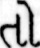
તો
